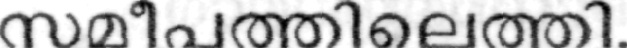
സമീപത്തിലെത്തി.
